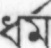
ধর্ম
